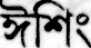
ঈশিং
